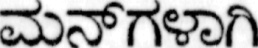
ಮನ್‌ಗಳಾಗಿ
